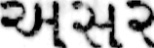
અસર
